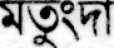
মতুংদা
